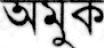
অমুক
